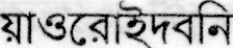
য়াওরোইদবনি
